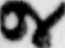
જ
